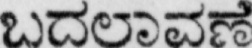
ಬದಲಾವಣೆ
